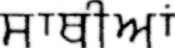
ਸਾਥੀਆਂ
